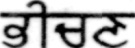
ਭੀਚਣ
